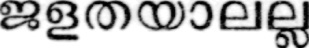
ജളതയാലല്ല
